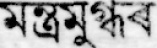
মন্ত্রমুগ্ধৰ
